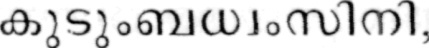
കുടുംബധ്വംസിനി,
